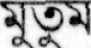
মুতুম
